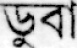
ডুবা
